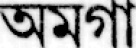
অমগা
